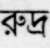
রুদ্র
